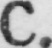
C.
